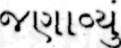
જણાવ્યું
